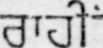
ਰਾਹੀਂ
